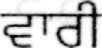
ਵਾਰੀ
